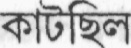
কাটছিল
